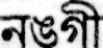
নঙগী
